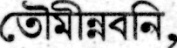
তৌমীন্নবনি,
